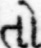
તો
